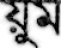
য়ুম
